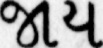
જાય
